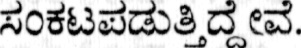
ಸಂಕಟಪಡುತ್ತಿದ್ದೇವೆ.
